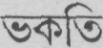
ভকতি
